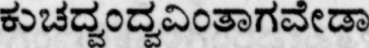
ಕುಚದ್ವಂದ್ವವಿಂತಾಗವೇಡಾ
